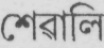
শেৱালি
